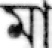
মা
